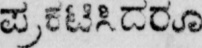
ಪ್ರಕಟಿಸಿದರೂ
